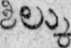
ಶಿಲ್ಕು
